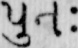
પુનઃ
